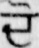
ਦੋ
